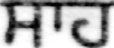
ਸਾਹ
